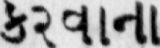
કરવાના
